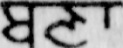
ਬਣਾ
